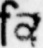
ਕਿ
